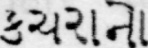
કચરાનો
